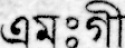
এমঃগী
